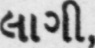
લાગી,
